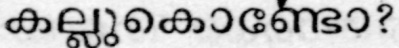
കല്ലുകൊണ്ടോ?
